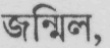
জন্মিল,
